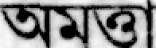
অমত্তা
